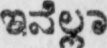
ಇವೆಲ್ಲಾ
